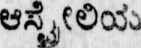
ಆಸ್ಟ್ರೇಲಿಯ
